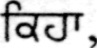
ਕਿਹਾ,
